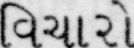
વિચારો
